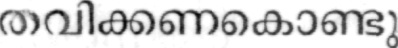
തവിക്കണകൊണ്ടു
